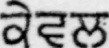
ਕੇਵਲ
